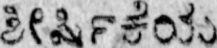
ಶೀರ್ಷಿಕೆಯ
